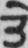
ਤੇ
